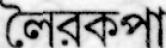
লৈরকপা
